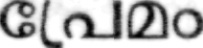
പ്രേമം
